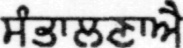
ਸੰਭਾਲਣਾਐ
